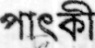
পাৎকী
